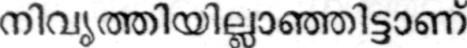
നിവൃത്തിയില്ലാഞ്ഞിട്ടാണ്
